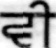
ਵੀ
